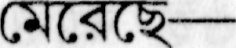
মেরেছে–
